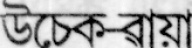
উচেক-ৱায়া
